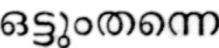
ഒട്ടുംതന്നെ
